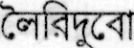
লৈরিদুবো
